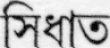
সিধাত
